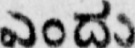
ಎಂದು
